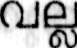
വല്ല
